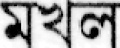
মখল
